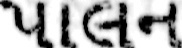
પાલન
